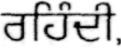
ਰਹਿੰਦੀ,
